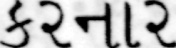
કરનાર
